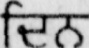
ਦਿਨ
